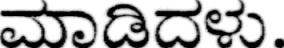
ಮಾಡಿದಳು.
